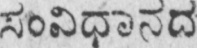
ಸಂವಿಧಾನದ
